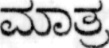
ಮಾತ್ರ
